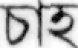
চাহ
